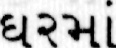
ઘરમાં
